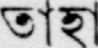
তাহা
